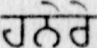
ਹਨੇਰੇ
